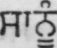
ਸਾਨੂੰ
